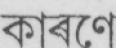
কাৰণে
